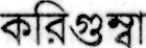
করিগুম্বা
